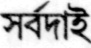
সর্বদাই
